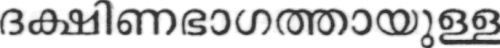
ദക്ഷിണഭാഗത്തായുള്ള
